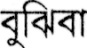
বুঝিবা
